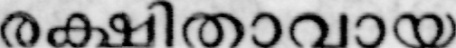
രക്ഷിതാവായ
